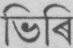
ভিৰি
